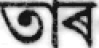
তাৰ
